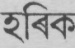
হৰিক
